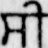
ਸੀ
